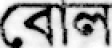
বোল
